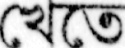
খেতে
